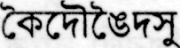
কৈদৌঙৈদসু
